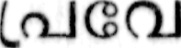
പ്രവേ
